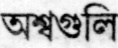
অশ্বগুলি
